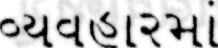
વ્યવહારમાં
